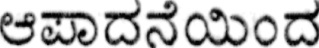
ಆಪಾದನೆಯಿಂದ
